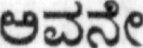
ಅವನೇ
